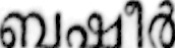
ബഷീര്‍
